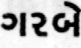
ગરબે
